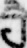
ਹੈ
